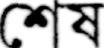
শেষ
